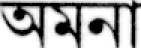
অমনা
